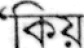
'কিয়
